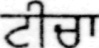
ਟੀਚਾ
